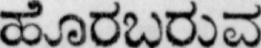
ಹೊರಬರುವ
